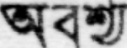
অবশ্য
